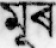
মূৰ
